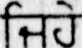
ਜਿਹੇ
